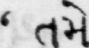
'તમે
